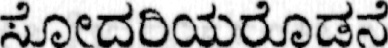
ಸೋದರಿಯರೊಡನೆ
